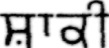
ਸ਼ਾਕੀ
